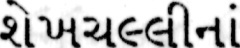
શેખચલ્લીનાં
